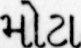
મોટા
